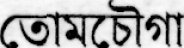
তোমচৌগা
